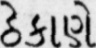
ઠેકાણે
